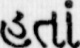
હતાં
